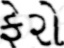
ફેરો
